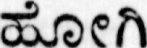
ಹೋಗಿ
